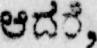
ಆದರೆ,
